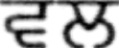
ਵਲ
